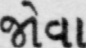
જોવા
